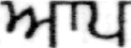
ਆਪ
